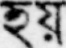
হয়
